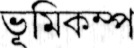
ভূমিকম্প
